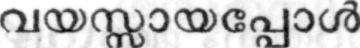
വയസ്സായപ്പോള്‍
